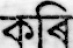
কৰি
